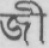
জী
